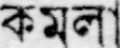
কমলা
